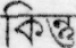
কিন্তু
